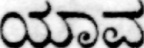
ಯಾವ
